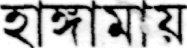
হাঙ্গামায়
